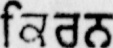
ਕਿਰਨ
